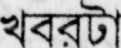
খবরটা
